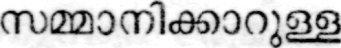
സമ്മാനിക്കാറുള്ള
